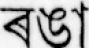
ৰঙা
